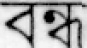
বন্ধ
